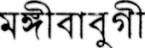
মঙ্গীবাবুগী
